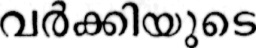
വര്‍ക്കിയുടെ
